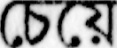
চেয়ে
